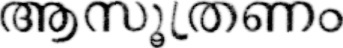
ആസൂത്രണം
